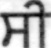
ਸੀ
